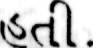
હતી.
